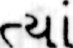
ત્યાં
